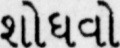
શોધવો
